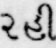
રહી
